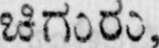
ಚಿಗುರು,
